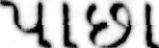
પાછા
